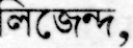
লিজেন্দ,
